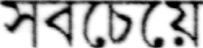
সবচেয়ে
